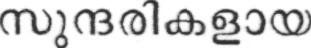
സുന്ദരികളായ
